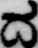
ದ
